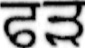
ਫੜ
